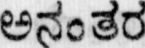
ಅನಂತರ
